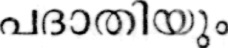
പദാതിയും
